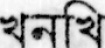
খনখি
